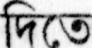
দিতে
